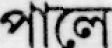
পালে
